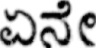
ಏನೇ
